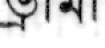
ড্রামা
